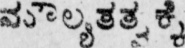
ಮೌಲ್ಯತತ್ವಕ್ಕೆ
